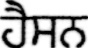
ਹੈਸਨ
